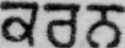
ਕਰਨ
